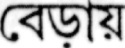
বেড়ায়
